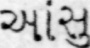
આંસુ
